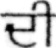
ਦੀ
